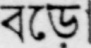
বড়ো
